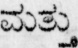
ಮತ್ತು
